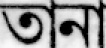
তানা
